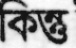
কিন্তু
